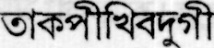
তাকপীখিবদুগী
